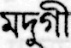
মদুগী
